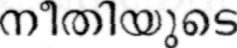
നീതിയുടെ
